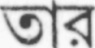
তার
